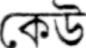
কেউ
